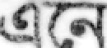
এনে
